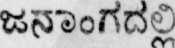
ಜನಾಂಗದಲ್ಲಿ
